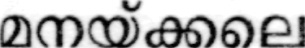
മനയ്ക്കലെ
